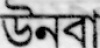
উনবা
